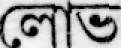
লোভ
